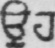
ਉਹ
